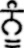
ਨੂੰ
